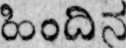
ಹಿಂದಿನ
